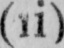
(ii)
